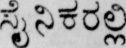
ಸೈನಿಕರಲ್ಲಿ
